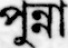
পুন্না
